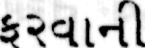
ફરવાની
